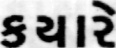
ક્યારે
